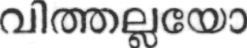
വിത്തല്ലയോ
